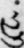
હું
